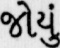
જોયું
